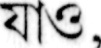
যাও,
